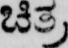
ಚಿತ್ರ
